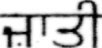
ਜ਼ਾਤੀ
